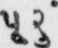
પૂરું
